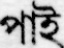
পাই
